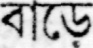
বাড়ে
